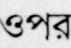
ওপর
